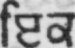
ਇਕ
